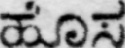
ಹೊಸ
